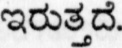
ಇರುತ್ತದೆ.
